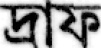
দ্রাফ
